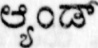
ಅಂಡ್
